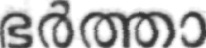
ഭര്‍ത്താ
